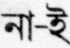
না-ই
